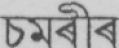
চমৰীৰ
